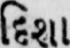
દિશા
